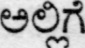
ಅಲ್ಲಿಗೆ
